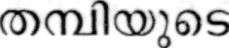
തമ്പിയുടെ
